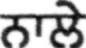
ਨਾਲੇ
